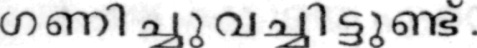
ഗണിച്ചുവച്ചിട്ടുണ്ട്.
